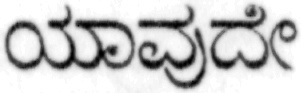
ಯಾವುದೇ
